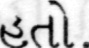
હતો.
